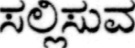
ಸಲ್ಲಿಸುವ
